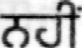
ਨਹੀਂ
